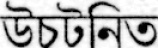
উচটনিত
